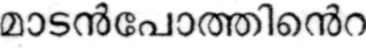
മാടന്‍പോത്തിന്റെ
